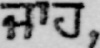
ਜਾਹ,
